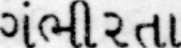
ગંભીરતા
